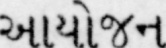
આયોજન
